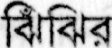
ঝিঁঝির
